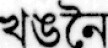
খঙনৈ
